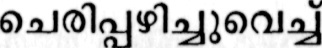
ചെരിപ്പഴിച്ചുവെച്ച്
